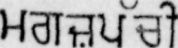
ਮਗਜ਼ਪੱਚੀ
